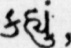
કહ્યું,
